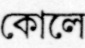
কোলে
